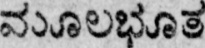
ಮೂಲಭೂತ
